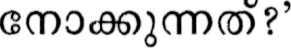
നോക്കുന്നത്?’
